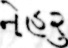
નેહરુ
